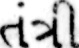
તંત્રી
